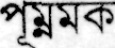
পূম্নমক
